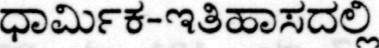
ಧಾರ್ಮಿಕ-ಇತಿಹಾಸದಲ್ಲಿ
